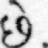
છે.
